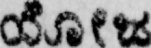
ಯೋಜ
